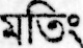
মতিং
